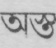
অস্ত
